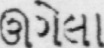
ઊગેલા
